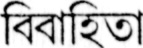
বিবাহিতা
